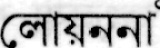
লোয়ননা
